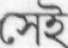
সেই
